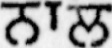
ਨਾਲ
